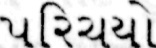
પરિચયો
